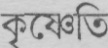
কৃষ্ণেতি
